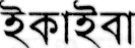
ইকাইবা
